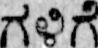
ಗಳಿಗೆ
